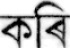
কৰি
